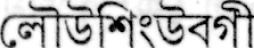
লৌউশিংউবগী
